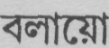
বলায়ো
